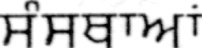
ਸੰਸਥਾਆਂ
